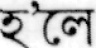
হ'লে
